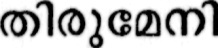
തിരുമേനി
